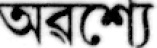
অৱশ্যে
